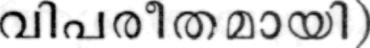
വിപരീതമായി)
